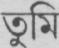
তুমি
